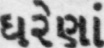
ઘરેણાં
